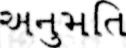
અનુમતિ
